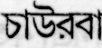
চাউরবা
